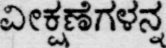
ವೀಕ್ಷಣೆಗಳನ್ನ
